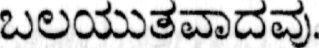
ಬಲಯುತವಾದವು.
